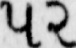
પર
